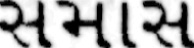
સમાસ
